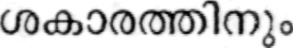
ശകാരത്തിനും
